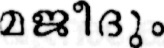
മജീദും
